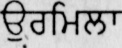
ਉਰਮਿਲਾ
